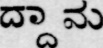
ದ್ದಾಮ
